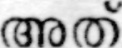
അത്
